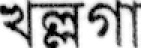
খল্লগা
